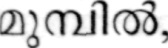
മുമ്പില്‍,
